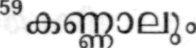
59കണ്ണാലും
